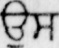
ਉਸ
